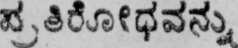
ಪ್ರತಿರೋಧವನ್ನು
